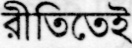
রীতিতেই
